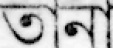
তানা
